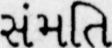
સંમતિ
